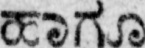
ಹಾಗೂ
